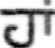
ਹਾਂ
